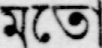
মতো
